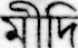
মীদি
